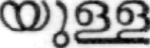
യുള്ള
